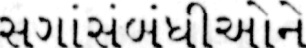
સગાંસંબંધીઓને
